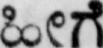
ಹೀಗೆ
